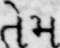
તેમ
